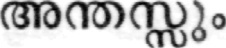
അന്തസ്സും
